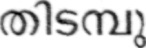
തിടമ്പു
